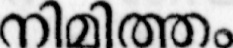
നിമിത്തം
